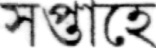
সপ্তাহে
